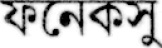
ফনেকসু
